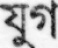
যুগ
